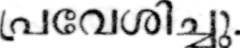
പ്രവേശിച്ചു.
